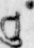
તું
